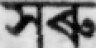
সৰু
